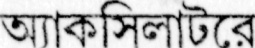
অ্যাকসিলাটরে
